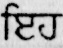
ਇਹ
